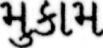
મુકામ
